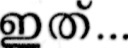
ഇത്...
